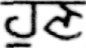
ਹੁਣ
